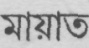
মায়াত
